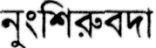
নুংশিরুবদা
